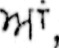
ਆਂ,
